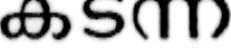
കടന്ന
